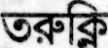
তরুক্নি
